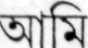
আমি
